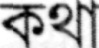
কথা
